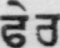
ਫੇਰ
